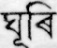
ঘূৰি
